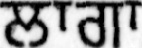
ਲਾਗਾ
